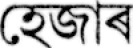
হেজাৰ
